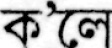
ক'লে
